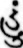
હું
